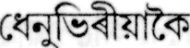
ধেনুভিৰীয়াকৈ
